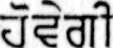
ਹੋਵੇਗੀ
